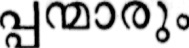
പ്പന്മാരും
